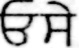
ਓਸੇ
